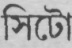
সিটো
